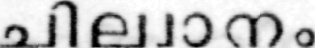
ചില്വാനം
